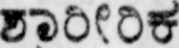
ಶಾರೀರಿಕ
